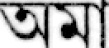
অমা
